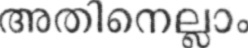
അതിനെല്ലാം
